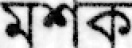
মশক
